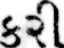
કરી
